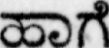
ಹಾಗೆ
